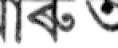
আৰু
